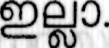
ഇല്ലാ.
